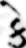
કે
